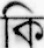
কি
